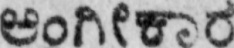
ಅಂಗೀಕಾರ
